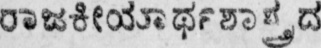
ರಾಜಕೀಯಾರ್ಥಶಾಸ್ತ್ರದ
